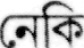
নেকি
